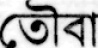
তৌবা
